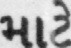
માટે
